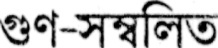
গুণ-সম্বলিত
